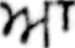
ਆ
